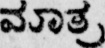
ಮಾತ್ರ
